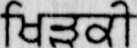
ਖਿੜਕੀ
